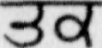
ਤਕ
